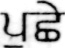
ਪੁਛੇ
